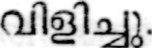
വിളിച്ചു.
